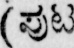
(ಪುಟ
